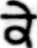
ਕੇ
